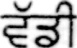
ਵੱਡੀ
